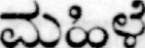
ಮಹಿಳೆ
